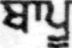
ਬਾਪੂ
